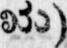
ಋ)
